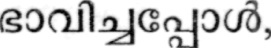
ഭാവിച്ചപ്പോള്‍,
